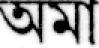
অমা
